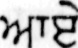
ਆਏ
